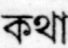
কথা
